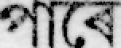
পাৰে
